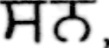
ਸਨ,
